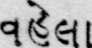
વહેલા
